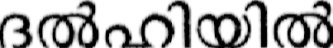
ദല്‍ഹിയില്‍
